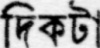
দিকটা
